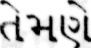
તેમણે
